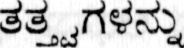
ತತ್ತ್ವಗಳನ್ನು
